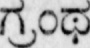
ಗ್ರಂಥ
